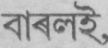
বাৰলই,
